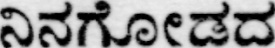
ನಿನಗೋಡದ
